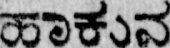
ಹಾಕುವ
